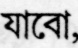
যাবো,
